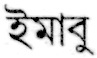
ইমাবু
